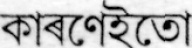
কাৰণেইতো
